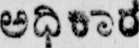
ಅಧಿಕಾರ
